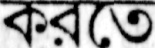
করতে
